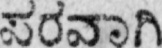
ಪರವಾಗಿ
